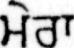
ਮੇਰਾ
